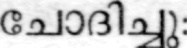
ചോദിച്ചു:
